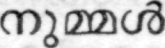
നുമ്മള്‍
